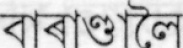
বাৰাণ্ডালৈ
